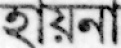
হায়না
